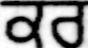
ਕਰ
